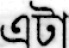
এটা
